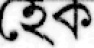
হেক
